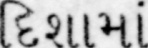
દિશામાં
